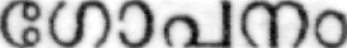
ഗോപനം
